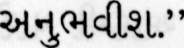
અનુભવીશ."
